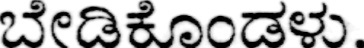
ಬೇಡಿಕೊಂಡಳು.
